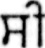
ਸੀ
